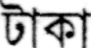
টাকা
